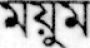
ময়ুম
